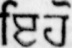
ਇਹੋ
